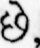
છે,
